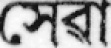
সেৱা
